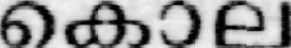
കൊല
